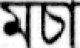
মচা
